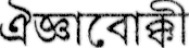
ঐজ্ঞাবোক্কী
